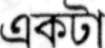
একটা
